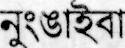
নুংঙাইবা
